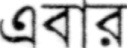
এবার
